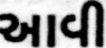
આવી
